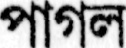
পাগল
